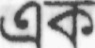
এক
